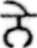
ਨੇ
